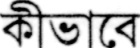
কীভাবে
